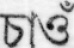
চাওঁ
